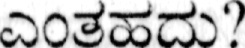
ಎಂತಹದು?
